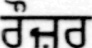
ਰੌਜ਼ਰ
